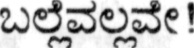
ಬಲ್ಲೆವಲ್ಲವೇ!
